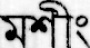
মশীং
